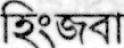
হিংজবা
